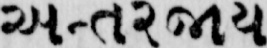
અન્તરજાય
